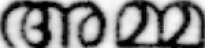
അമ്മ
